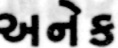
અનેક
